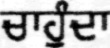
ਚਾਹੁੰਦਾ
